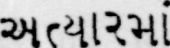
અત્યારમાં
